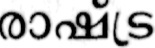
രാഷ്ട്ര
